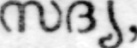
സദ്യ,
